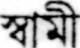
স্বামী
